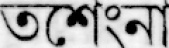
তশেংনা
